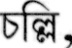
চল্লি,
